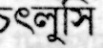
চৎলুসি
